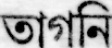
তাগনি
